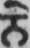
ਨੇ
